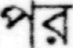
পর
